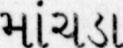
માંચડા
